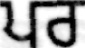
ਪਰ
